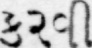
કરવી
